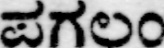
ಪಗಲಂ
